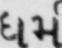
ધર્મ
